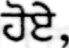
ਹੋਏ,
